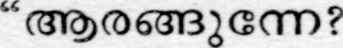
"ആരങ്ങുന്നേ?
